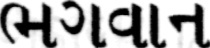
ભગવાન
